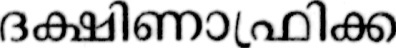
ദക്ഷിണാഫ്രിക്ക
